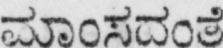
ಮಾಂಸದಂತೆ
